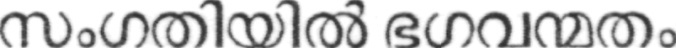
സംഗതിയില്‍ഭഗവന്മതം
